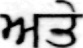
ਅਤੇ
